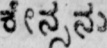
ಕೇನ್ಸನು
